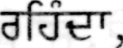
ਰਹਿੰਦਾ,
